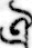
ঐ
